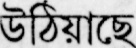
উঠিয়াছে
